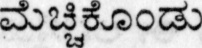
ಮೆಚ್ಚಿಕೊಂಡು
